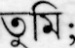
তুমি;
